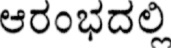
ಆರಂಭದಲ್ಲಿ
